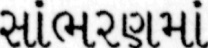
સાંભરણમાં
